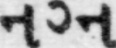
નગ્ન
